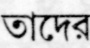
তাদের
